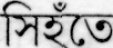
সিহঁতে
